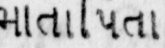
માતાાપતા
